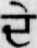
ਦੇ
